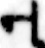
ન
